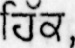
ਹਿੱਕ,
